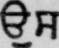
ਉਸ
